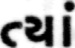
ત્યાં
